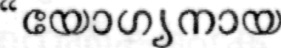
"യോഗ്യനായ
